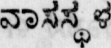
ವಾಸಸ್ಥಳ
